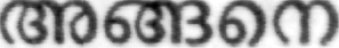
അങ്ങനെ
